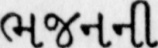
ભજનની
